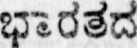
ಭಾರತದ
